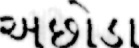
અછોડા
